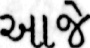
આજે
